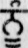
ਨੂੰ
